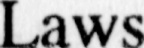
Laws
